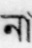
না
